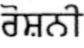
ਰੋਸ਼ਨੀ
